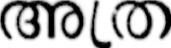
അത്ര
